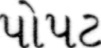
પોપટ
